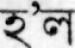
হ'ল
